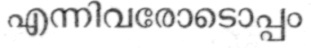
എന്നിവരോടൊപ്പം
